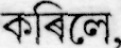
কৰিলে,
